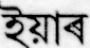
ইয়াৰ
